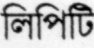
লিপিটি
